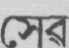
সেৱ
